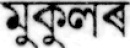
মুকুলৰ
